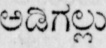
ಅಡಿಗಲ್ಲು
